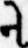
ને
